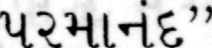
પરમાનંદ"
